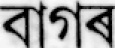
বাগৰ
